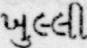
ખુલ્લી
